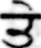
ਤੇ
